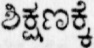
ಶಿಕ್ಷಣಕ್ಕೆ
